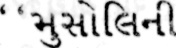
"મુસોલિની
